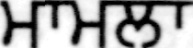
ਮਾਮਲਾ
